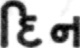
દિન
